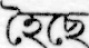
হৈছে
